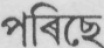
পৰিছে
